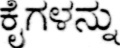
ಕೈಗಳನ್ನು
